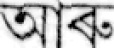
আৰু
